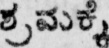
ಶ್ರಮಕ್ಕೆ
